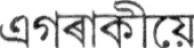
এগৰাকীয়ে
